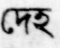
দেহ
